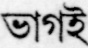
ভাগই
